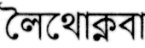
লৈথোক্নবা
